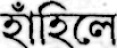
হাঁহিলে
